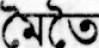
মৈতৈ
